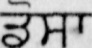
ਡੋਸਾ
